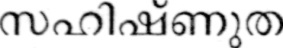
സഹിഷ്ണുത
